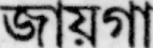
জায়গা
